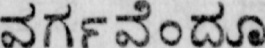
ವರ್ಗವೆಂದೂ
